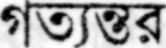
গত্যন্তর
